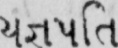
યજ્ઞપતિ
